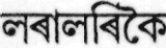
লৰালৰিকৈ
